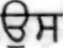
ਉਸ
